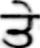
ਤੇ
